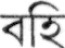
বহি
